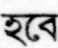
হবে
